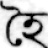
হৈ
